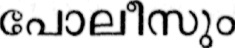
പോലീസും
